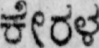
ಕೇರಳ
